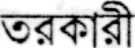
তরকারী
